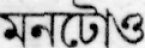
মনটোও
